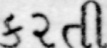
કરતી
